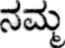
ನಮ್ಮ
